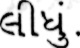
લીધું.
